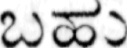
ಬಹು
